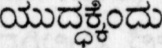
ಯುದ್ಧಕ್ಕೆಂದು
